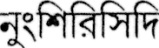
নুংশিরিসিদি
